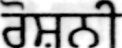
ਰੋਸ਼ਨੀ
